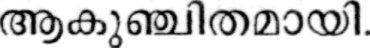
ആകുഞ്ചിതമായി.
